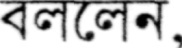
বললেন,
